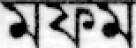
মফম
